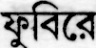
ফুবিরে
